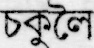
চকুলৈ
